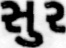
સુર
